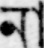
না
